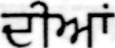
ਦੀਆਂ
